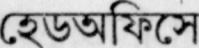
হেডঅফিসে
